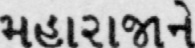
મહારાજાને
